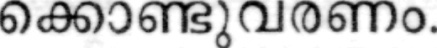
ക്കൊണ്ടുവരണം.
